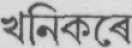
খনিকৰে
